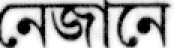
নেজানে
